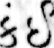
કંઇ
